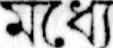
মধ্যে
